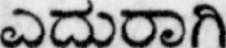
ಎದುರಾಗಿ
